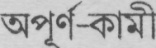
অপূৰ্ণ-কামী
